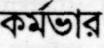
কর্মভার
